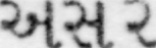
અસર
